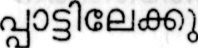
പ്പാട്ടിലേക്കു
